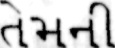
તેમની
